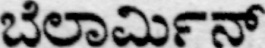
ಬೆಲಾರ್ಮಿನ್
